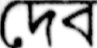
দেব
